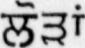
ਲੋੜਾਂ
